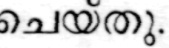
ചെയ്തു.
